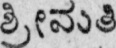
ಶ್ರೀಮತಿ
